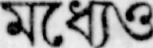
মধ্যেও
